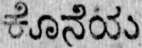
ಕೊನೆಯ
